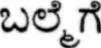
ಬಲ್ಮೆಗೆ
